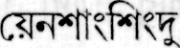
য়েনশাংশিংদু
